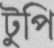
টুপি
